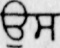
ਉਸ
